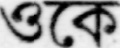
ওকে
